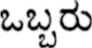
ಒಬ್ಬರು
